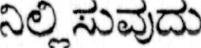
ನಿಲ್ಲಿಸುವುದು
